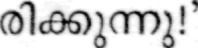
രിക്കുന്നു!’
